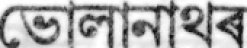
ভোলানাথৰ
